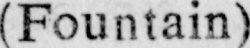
(Fountain)
